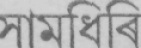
সামধিৰি
